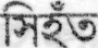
সিহঁত
